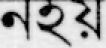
নহয়
